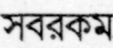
সবরকম
